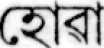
হোৱা
